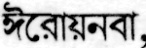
ঈরোয়নবা,
